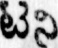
ಟನಿ
